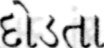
દોડતા
